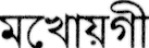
মখোয়গী
